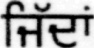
ਜਿੱਦਾਂ
